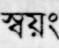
স্বয়ং
